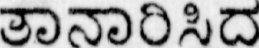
ತಾನಾರಿಸಿದ
